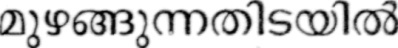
മുഴങ്ങുന്നതിടയില്‍
